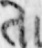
તો
